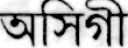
অসিগী
